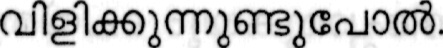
വിളിക്കുന്നുണ്ടുപോല്‍.
